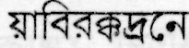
য়াবিরক্কদ্রনে
